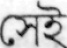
সেই
